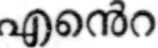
എന്റെ
